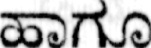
ಹಾಗೂ
